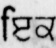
ਇਕ
